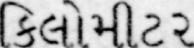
કિલોમીટર
